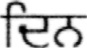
ਦਿਨ
